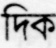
দিক
